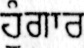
ਹੁੰਗਾਰ
